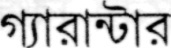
গ্যারান্টার
